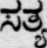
ಸತ್ಯ
